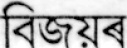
বিজয়ৰ
